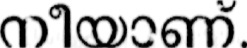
നീയാണ്.
